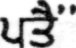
ਪਤੈ''
